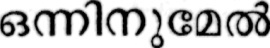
ഒന്നിനുമേല്‍
